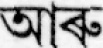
আৰু
